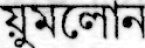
য়ুমলোন
